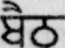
ਬੈਠ
